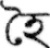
হৈ
